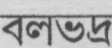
বলভদ্ৰ
